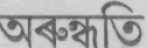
অৰুন্ধতি
